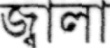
জ্বালা
